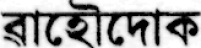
ৱাহৌদোক
